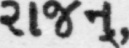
રાજન્,
